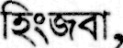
হিংজবা,
